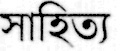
সাহিত্য
